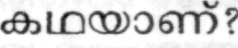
കഥയാണ്?
